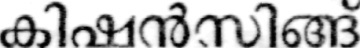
കിഷന്‍സിങ്ങ്
